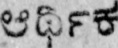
ಅರ್ಥಿಕ
